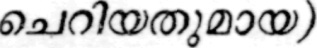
ചെറിയതുമായ)
